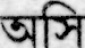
অসি
